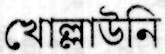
খোল্লাউনি
